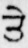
ਤੇ
